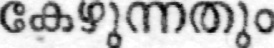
കേഴുന്നതും
